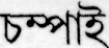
চম্পাই
